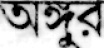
অঙ্গুর
